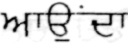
ਆਉਂਦਾ
